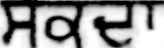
ਸਕਦਾ
